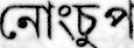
নোংচুপ
